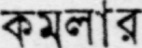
কমলার
